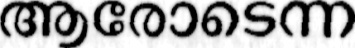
ആരോടെന്ന
